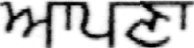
ਆਪਣਾ
